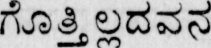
ಗೊತ್ತಿಲ್ಲದವನ
